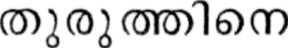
തുരുത്തിനെ
